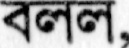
বলল,
